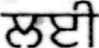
ਲਈ
